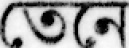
তেনে
